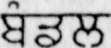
ਬੰਡਲ
